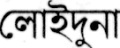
লোইদুনা
